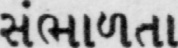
સંભાળતા
